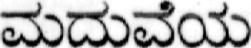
ಮದುವೆಯ
